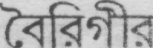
বৈরিগীর
